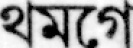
থমগে
